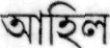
আহিল
